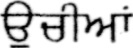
ਉਚੀਆਂ
